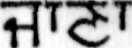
ਜਾਣਾ
